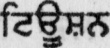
ਟਿਊਸ਼ਨ
